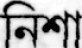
নিশা
